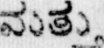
ಮತ್ತು
